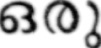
ഒരു
